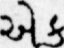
એક
